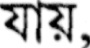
যায়,
